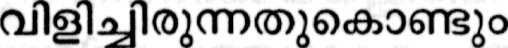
വിളിച്ചിരുന്നതുകൊണ്ടും
